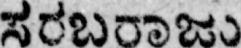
ಸರಬರಾಜು
